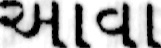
આવા
